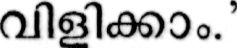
വിളിക്കാം.’
